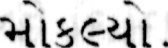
મોકલ્યો.
